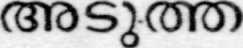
അടുത്ത
